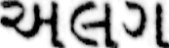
અલગ
